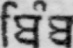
ਬਿੰਬ
